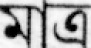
মাত্র
